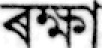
ৰক্ষা
